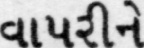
વાપરીને
